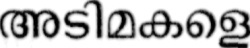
അടിമകളെ
